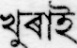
খুৰাই
